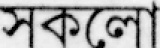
সকলো
